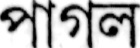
পাগল
